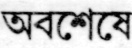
অবশেষে
